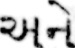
અને
